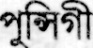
পুন্সিগী
